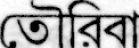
তৌরিবা
